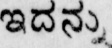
ಇದನ್ನು
